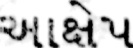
આક્ષેપ
